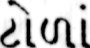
ટોળાં
